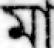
মা
